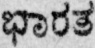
ಭಾರತ
